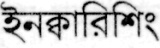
ইনক্বারিশিং
